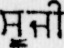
ਸੂਜੀ
